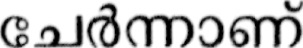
ചേര്‍ന്നാണ്
